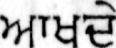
ਆਖਦੇ
